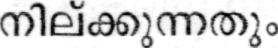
നില്ക്കുന്നതും
